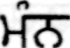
ਮੰਨ
